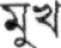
মুখ
